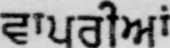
ਵਾਪਰੀਆਂ
